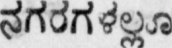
ನಗರಗಳಲ್ಲೂ
